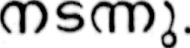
നടന്നു.
